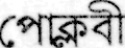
পোক্লবী
